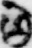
છે
